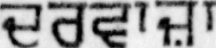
ਦਰਵਾਜ਼ਾ
